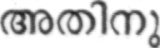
അതിനു
